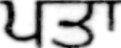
ਪਤਾ
